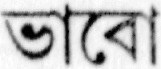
ভাবো
